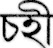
চহী
